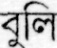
বুলি
